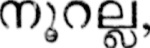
നൂറല്ല,
